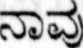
ನಾವು
